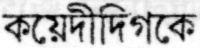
কয়েদীদিগকে
